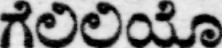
ಗೆಲಿಲಿಯೊ
